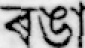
ৰঙা
